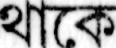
থাকে
